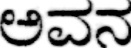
ಅವನ
